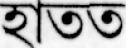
হাতত
